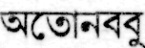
অতোনববু
